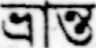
ভ্রান্ত
